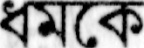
ধমকে
